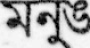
মনুঙ
